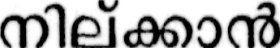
നില്ക്കാന്‍
